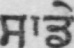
ਸਾਡੇ
